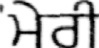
'ਮੇਰੀ
